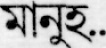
মানুহ..
